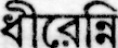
ধীরেন্নি
